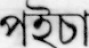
পইচা
